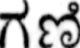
ಗಣಿ
